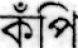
কঁপি
